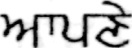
ਆਪਣੇ
